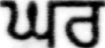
ਘਰ
